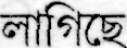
লাগিছে
